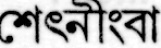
শেৎনীংবা
